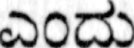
ಎಂದು
